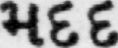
મદદ
